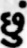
છું
